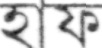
হাফ
